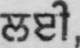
ਲਈ,
